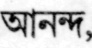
আনন্দ,
